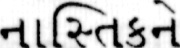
નાસ્તિકને
